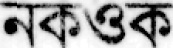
নকওক
